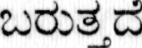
ಬರುತ್ತದೆ
